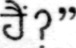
ਹੈਂ?''
